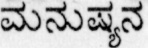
ಮನುಷ್ಯನ
